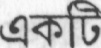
একটি
